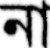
না
